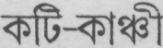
কটি-কাঞ্চী
